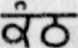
ਕੰਠ
